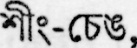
শীং-চেঙ,
